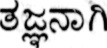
ತಜ್ಞನಾಗಿ
